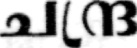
ചന്ദ്ര
